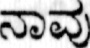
ನಾವು
